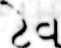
ટેવ
